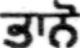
ਭਾਨੋ
